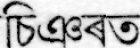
চিঞৰত
